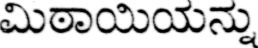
ಮಿಠಾಯಿಯನ್ನು
